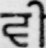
ਵੀ
